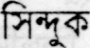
সিন্দুক
